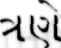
ત્રણે
